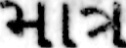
માત્ર
